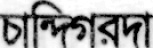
চান্দিগরদা
